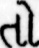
તો
